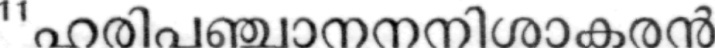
11ഹരിപഞ്ചാനനനിശാകരന്‍
